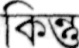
কিন্তু
